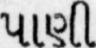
પાણી
